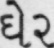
ઘેર
